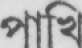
পাখি
